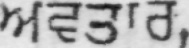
ਅਵਤਾਰ,
